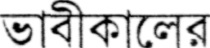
ভাবীকালের
